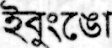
ইবুংঙো
